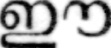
ഈ
